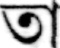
তা
